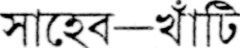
সাহেব–খাঁটি
